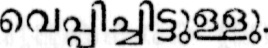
വെപ്പിച്ചിട്ടുള്ളു.
